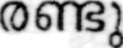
രണ്ടു
